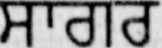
ਸਾਗਰ
